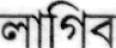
লাগিব
